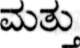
ಮತ್ತು
